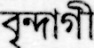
বৃন্দাগী
